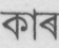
কাৰ
